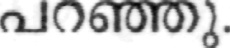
പറഞ്ഞു.
